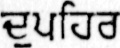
ਦੁਪਹਿਰ
